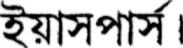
ইয়াসপার্স।
